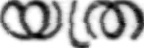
യത്ര
